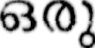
ഒരു
